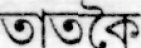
তাতকৈ
